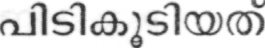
പിടികൂടിയത്
